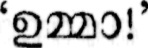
‘ഉമ്മാ!’
